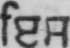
ਇਸ
